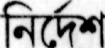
নির্দেশ
